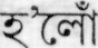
হ'লোঁ
